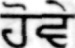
ਹੋਵੇ
